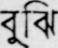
বুঝি
